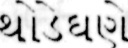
થોડેઘણે
